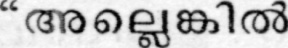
"അല്ലെങ്കില്‍
